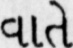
વાતે
